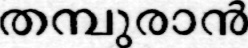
തമ്പുരാന്‍
